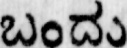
ಬಂದು
